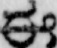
ಈ
